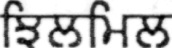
ਝਿਲਮਿਲ
